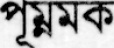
পূম্নমক
